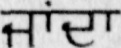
ਜਾਂਦਾ
